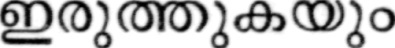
ഇരുത്തുകയും
